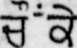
ਚੌਂਕੇ
